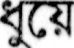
ধুয়ে
